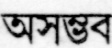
অসম্ভব
